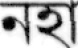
নহা
